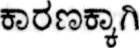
ಕಾರಣಕ್ಕಾಗಿ
